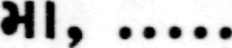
મા,.....
